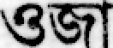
ওজা
